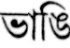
ভাঙি
